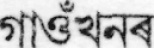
গাওঁখনৰ
